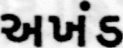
અખંડ
